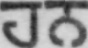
ਹਨ
